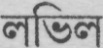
লভিল
